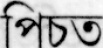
পিচত
